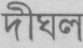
দীঘল
